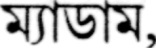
ম্যাডাম,
